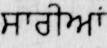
ਸਾਰੀਆਂ
